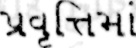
પ્રવૃત્તિમાં
